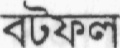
বটফল
